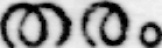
തരം
